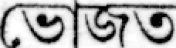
ভোজত
